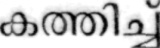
കത്തിച്ച്
